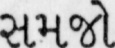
સમજો
